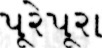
પૂરેપૂરા
